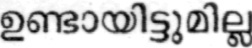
ഉണ്ടായിട്ടുമില്ല
